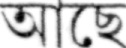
আছে
